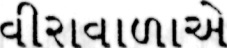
વીરાવાળાએ
